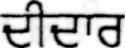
ਦੀਦਾਰ
